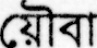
য়ৌবা
